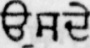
ਉਸਦੇ
